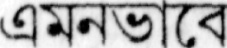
এমনভাবে
